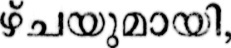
ഴ്ചയുമായി,
